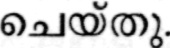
ചെയ്തു.
